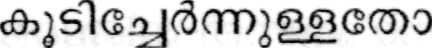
കൂടിച്ചേര്‍ന്നുള്ളതോ
